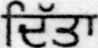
ਦਿੱਤਾ
